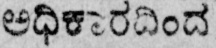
ಅಧಿಕಾರದಿಂದ
